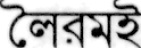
লৈরমই
